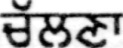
ਚੱਲਣਾ
